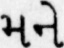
મને
